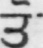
ਤੋਂ
